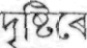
দৃষ্টিৰে
